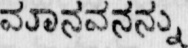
ಮಾನವನನ್ನು
